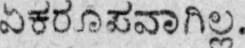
ಏಕರೂಪವಾಗಿಲ್ಲ.
